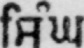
ਸਿੰਘ
